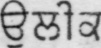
ਉਲੀਕ
